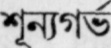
শূন্যগর্ভ
